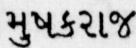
મુષકરાજ
